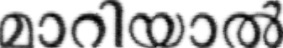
മാറിയാല്‍
